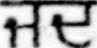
ਜਦ
